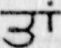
ਤਾਂ
